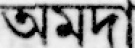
অমদা
